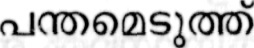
പന്തമെടുത്ത്
